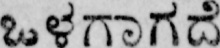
ಒಳಗಾಗದೆ
